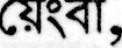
য়েংবা,
